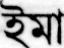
ইমা
